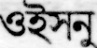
ওইসনু
